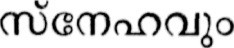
സ്നേഹവും
